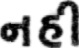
નહી
